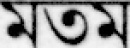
মতম
